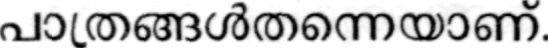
പാത്രങ്ങള്‍തന്നെയാണ്.
